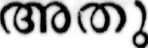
അതു
